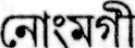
নোংমগী
